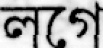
লগে
